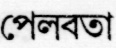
পেলবতা
